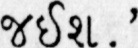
જઈશ.'
